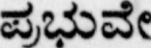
ಪ್ರಭುವೇ
